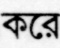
করে
